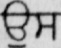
ਉਸ
